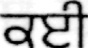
ਕਈ
